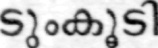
ടുംകൂടി
